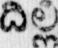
ದಿಲ್ಲಿ
